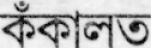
কঁকালত
